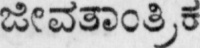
ಜೀವತಾಂತ್ರಿಕ
